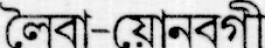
লৈবা-য়োনবগী
